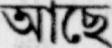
আছে
